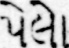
પેલો
